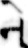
ને
